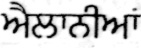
ਐਲਾਨੀਆਂ
